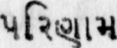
પરિણામ
